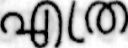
എത്ര
